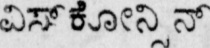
ವಿಸ್‌ಕೋನ್ಸಿನ್
